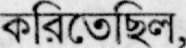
করিতেছিল,
